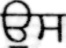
ਉਸ
